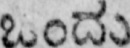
ಒಂದು
